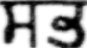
ਸਭ
